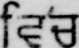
ਵਿਚ
